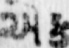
એક
